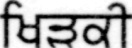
ਖਿੜਕੀ
